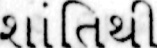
શાંતિથી
